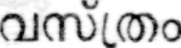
വസ്ത്രം
